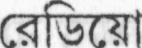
রেডিয়ো
